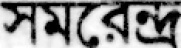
সমরেন্দ্র
